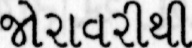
જોરાવરીથી
